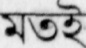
মতই
